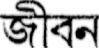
জীবন
